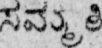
ಸಮ್ಮತಿ
